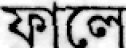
ফালে
